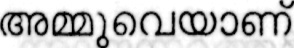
അമ്മുവെയാണ്
